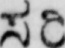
ಸರಿ
